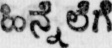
ಹಿನ್ನೆಲೆಗೆ
